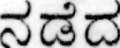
ನಡೆದ
